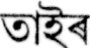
তাইৰ
